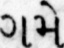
ગમે
